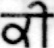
ਕੀ
